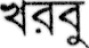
খরবু
